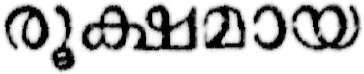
രൂക്ഷമായ
